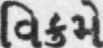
વિક્રમે
